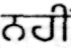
ਨਹੀਂ
